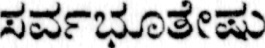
ಸರ್ವಭೂತೇಷು
